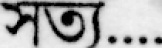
সত্য....
